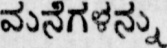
ಮನೆಗಳನ್ನು
